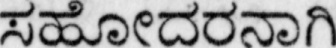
ಸಹೋದರನಾಗಿ
